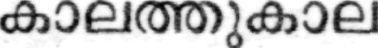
കാലത്തുകാല
